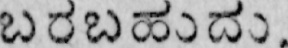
ಬರಬಹುದು.
